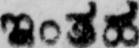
ಇಂತಹ
